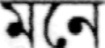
মনে
